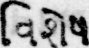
વિશેષ
